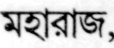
মহারাজ,
